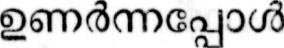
ഉണര്‍ന്നപ്പോള്‍
